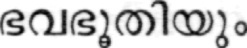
ഭവഭൂതിയും
